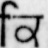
ਕਿ
